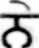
ਨੇ
